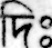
দিঃ
